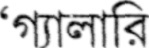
'গ্যালারি
